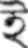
ই
